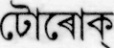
টোৰোক্
